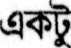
একটু
